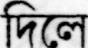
দিলে
